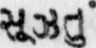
સૂઝતું
